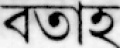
বতাহ
